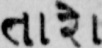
તારો
